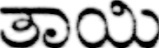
ತಾಯಿ
